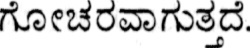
ಗೋಚರವಾಗುತ್ತದೆ.
